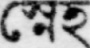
স্নেহ
